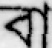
বা
